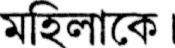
মহিলাকে।
